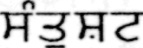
ਸੰਤੁਸ਼ਟ
